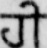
ਹੀ
